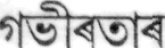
গভীৰতাৰ
